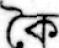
কৈ
